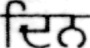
ਦਿਨ
